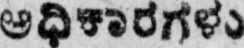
ಅಧಿಕಾರಗಳು
